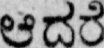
ಆದರೆ
